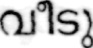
വീടു
